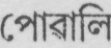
পোৱালি
